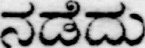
ನಡೆದು
